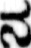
ನ
